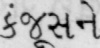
કંજૂસને
